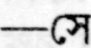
–সে
